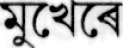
মুখেৰে
